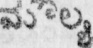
ಮೌಲ್ಯ
